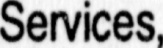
Services,
